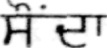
ਸੌਂਦਾ
